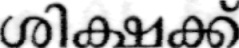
ശിക്ഷക്ക്
